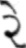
રે
